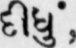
દીધું,
